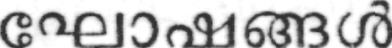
ഘോഷങ്ങള്‍
